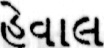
હેવાલ
